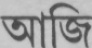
আজি
